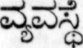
ವ್ಯವಸ್ಥೆ
